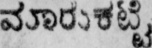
ಮಾರುಕಟ್ಟೆ
